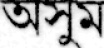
অসুম
